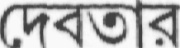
দেবতার
